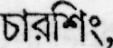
চারশিং,
